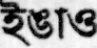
ইঙাও
